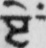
ਏਂ
